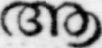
ആ
